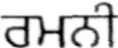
ਰਮਨੀ
